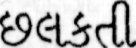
છલકતી
